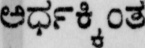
ಅರ್ಧಕ್ಕಿಂತ
